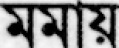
মমায়
